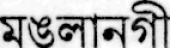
মঙলানগী
